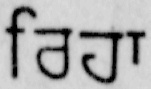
ਰਿਹਾ
